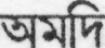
অমদি
